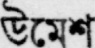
উমেশ
